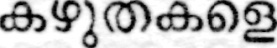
കഴുതകളെ
